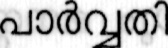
പാര്‍വ്വതി
